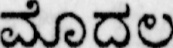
ಮೊದಲ
